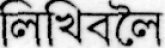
লিখিবলৈ
